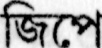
জিপে
